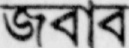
জবাব
